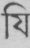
যি
